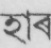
হাৰ
